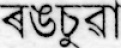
ৰঙচুৱা
